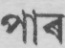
পাৰ
